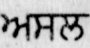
ਅਸਲ
